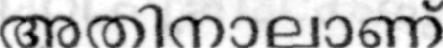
അതിനാലാണ്
